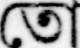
তো
